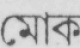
মোক
